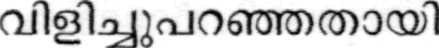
വിളിച്ചുപറഞ്ഞതായി
